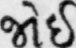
જોઈ
